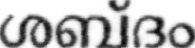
ശബ്ദം
